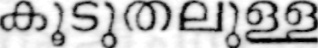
കൂടുതലുള്ള
